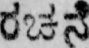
ರಚನೆ
